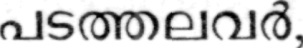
പടത്തലവര്‍,
